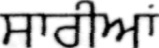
ਸਾਰੀਆਂ
